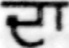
ਦਾ
